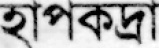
হাপকদ্রা
